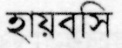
হায়বসি
